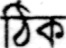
ঠিক
